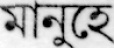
মানুহে
